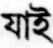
যাই
